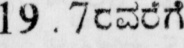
19.7ರವರೆಗೆ
